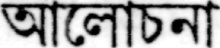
আলোচনা
